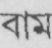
বাম
